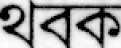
থবক
